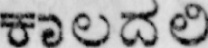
ಕಾಲದಲಿ
